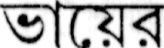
ভায়ের
